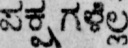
ಪಕ್ಷಗಳೆಲ್ಲ
